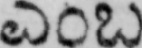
ಎಂಬ
